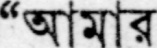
‘‘আমার
